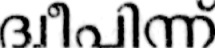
ദ്വീപിന്ന്
